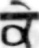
ਕੇ
